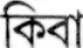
কিবা
